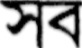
সব
